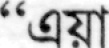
"এয়া
